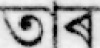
তাৰ
